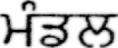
ਮੰਡਲ
